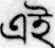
এই
